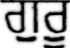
ਗੁਰੂ
